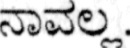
ನಾವಲ್ಲ.
